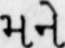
મને
